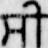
ਸੀ
